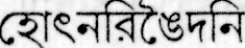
হোৎনরিঙৈদনি
